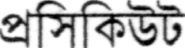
প্রসিকিউট
